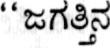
"ಜಗತ್ತಿನ
